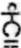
ਨੂੰ
